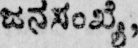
ಜನಸಂಖ್ಯೆ,
